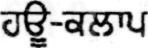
ਹਊ-ਕਲਾਪ
